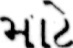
માટે
